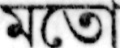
মতো
